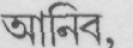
আনিব,
